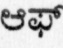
ಆಫ್
